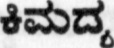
ಕಿಮದ್ಯ
